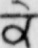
ਕੇ
